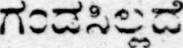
ಗಂದಸಿಲ್ಲದೆ
